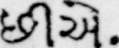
છીએ.
